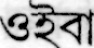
ওইবা
